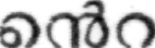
ന്റെ
